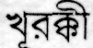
খূরক্কী
